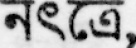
নৎত্রে,
